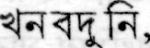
খনবদুনি,
